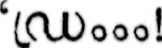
‘ഡ്രംംം!
